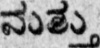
ಮತ್ತು
